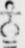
ਨੂੰ
